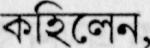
কহিলেন,
